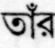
তাঁর
